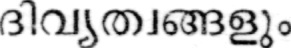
ദിവ്യത്വങ്ങളും
